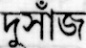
দুসাঁজ
